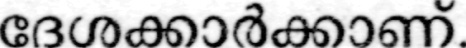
ദേശക്കാര്‍ക്കാണ്.
